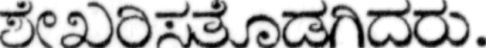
ಶೇಖರಿಸತೊಡಗಿದರು.
